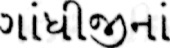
ગાંધીજીનાં
